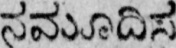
ನಮೂದಿಸ
